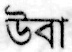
উবা
